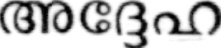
അദ്ദേഹ
